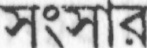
সংসার
